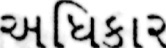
અધિકાર
